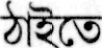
ঠাইতে
